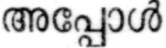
അപ്പോള്‍
